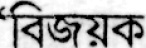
'বিজয়ক
